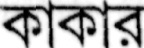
কাকার
